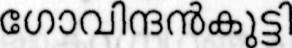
ഗോവിന്ദന്‍കുട്ടി
